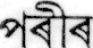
পৰীৰ
